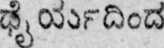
ಧೈರ್ಯದಿಂದ
